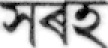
সৰহ
